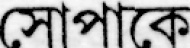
সোপাকে
